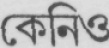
কেনিও
